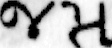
જપ્ત
